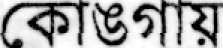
কোঙগায়
